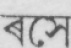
ৰসে
